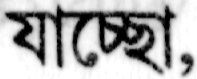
যাচ্ছো,
